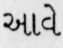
આવે
